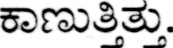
ಕಾಣುತ್ತಿತ್ತು.
